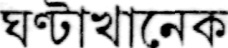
ঘন্টাখানেক
